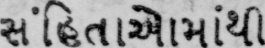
સંહિતાઓમાંથી
